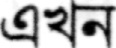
এখন
